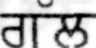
ਗੱਲ
